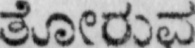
ತೋರುವ
